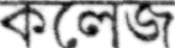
কলেজ
